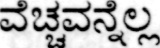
ವೆಚ್ಚವನ್ನೆಲ್ಲ
